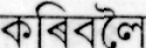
কৰিবলৈ
